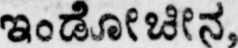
ಇಂಡೋಚೀನ,
